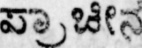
ಪ್ರಾಚೀನ
